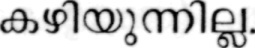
കഴിയുന്നില്ല.
